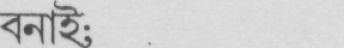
বনাই;
